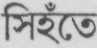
সিহঁতে
